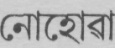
নোহোৱা
